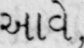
આવે,
